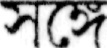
সঙ্গে
